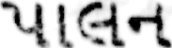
પાલન
